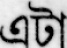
এটা
